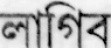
লাগিব
